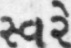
સ્વરે
